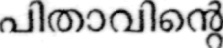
പിതാവിന്റെ
